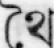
থৈ
